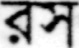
রস
